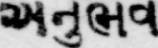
અનુભવ
